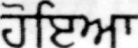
ਹੋਇਆ
